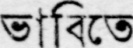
ভাবিতে
